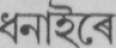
ধনাইৰে
